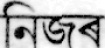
নিজৰ
